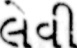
લેવી
